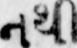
નથી
